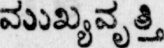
ಮುಖ್ಯವೃತ್ತಿ
